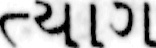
ત્યાગ
